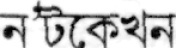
ন'টকেখন
